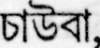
চাউবা,
